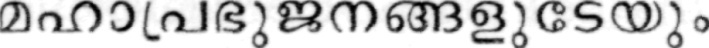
മഹാപ്രഭുജനങ്ങളുടേയും
